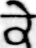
ਕੇ
